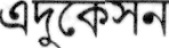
এদুকেসন
